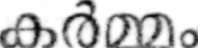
കര്‍മ്മം
